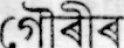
গৌৰীৰ
